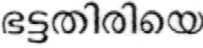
ഭട്ടതിരിയെ
